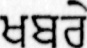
ਖਬਰੇ
